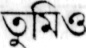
তুমিও
